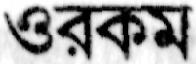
ওরকম
